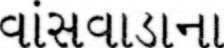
વાંસવાડાના
